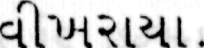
વીખરાયા.
